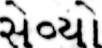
સેવ્યો
